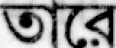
তারে
